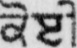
ਕੋਈ
